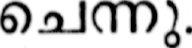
ചെന്നു.
